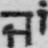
ਜਾਂ
